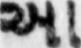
આ
